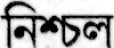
নিশ্চল
